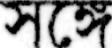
সঙ্গে
